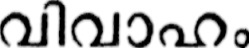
വിവാഹം
